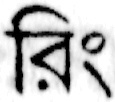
রিং
